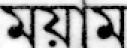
ময়াম
